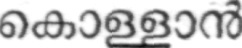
കൊള്ളാന്‍
